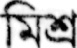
মিশ্র
